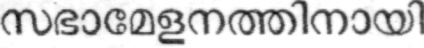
സഭാമേളനത്തിനായി
